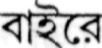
বাইরে
